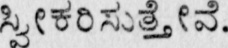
ಸ್ವೀಕರಿಸುತ್ತೇವೆ.
